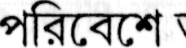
পরিবেশে
